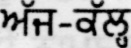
ਅੱਜ-ਕੱਲ੍ਹ
